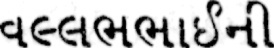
વલ્લભભાઈની
